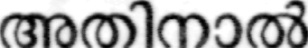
അതിനാല്‍
